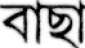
বাছা
